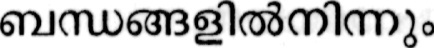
ബന്ധങ്ങളില്‍നിന്നും
